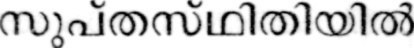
സുപ്തസ്ഥിതിയില്‍
